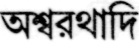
অশ্বরথাদি
